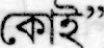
কৌই”
